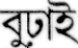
বুঢ়াই
